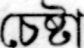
চেষ্টা
